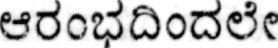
ಆರಂಭದಿಂದಲೇ
